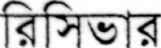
রিসিভার
